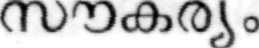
സൌകര്യം
